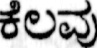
ಕೆಲವು
